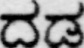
ದಡ
